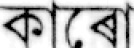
কাৰো
